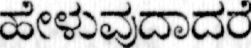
ಹೇಳುವುದಾದರೆ
